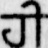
ਹੀ
